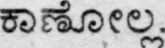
ಕಾಣೋಲ್ಲ.
